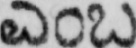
ಎಂಬ
